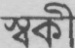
স্বকী
